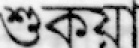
শুকয়া
